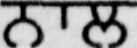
ਨਾਲ
